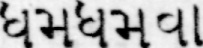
ધમધમવા
